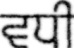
ਵਧੀ
